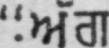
''ਅੱਗ
